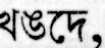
খঙদে,
